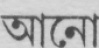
আনো
